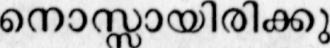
നൊസ്സായിരിക്കു
